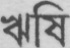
ঋষি
